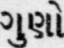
ગુણો
